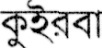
কুইরবা
